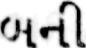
બની
